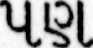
પણ
